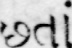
છતાં
